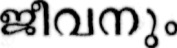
ജീവനും
